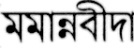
মমান্নবীদা
